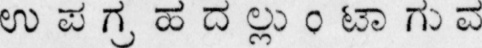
ಉಪಗ್ರಹದಲ್ಲುಂಟಾಗುವ
